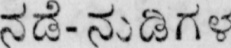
ನಡೆ-ನುಡಿಗಳ
